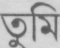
তুমি
